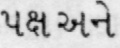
પક્ષઅને
